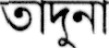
তাদুনা
